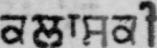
ਕਲਾਸਕੀ
